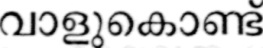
വാളുകൊണ്ട്
